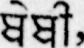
ਬੇਬੀ,
